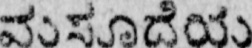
ಮಸೂದೆಯ
